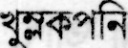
খুম্লকপনি
